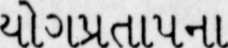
યોગપ્રતાપના
